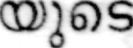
യുടെ
